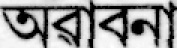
অৱাবনা
